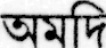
অমদি
